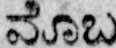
ಮೊಬ
